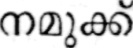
നമുക്ക്
